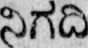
ನಿಗದಿ
